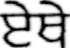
ਏਥੇ
